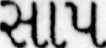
સાપ
